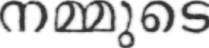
നമ്മുടെ
